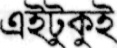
এইটুকুই
